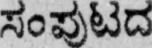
ಸಂಪುಟದ
